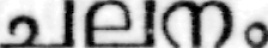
ചലനം
